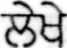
ਲੇਖੇ
